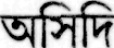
অসিদি
